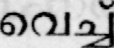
വെച്ച്
